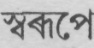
স্বৰূপে
